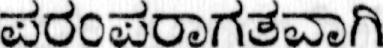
ಪರಂಪರಾಗತವಾಗಿ
